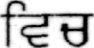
ਵਿਚ
